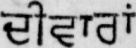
ਦੀਵਾਰਾਂ
